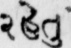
રહેતું
